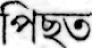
পিছত
